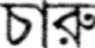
চারু
